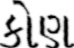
કોણ
